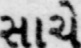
સાચે
